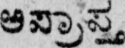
ಅಪ್ರಾಪ್ತ
